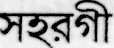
সহরগী
